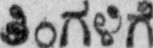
ತಿಂಗಳಿಗೆ
